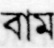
বাম
